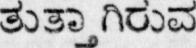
ತುತ್ತಾಗಿರುವ
